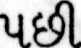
પછી
